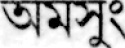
অমসুং
